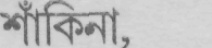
শাঁকিনা,
